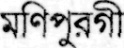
মণিপুরগী
